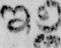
ಇಲ್ಲಿ
